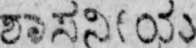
ಶಾಸನೀಯ
